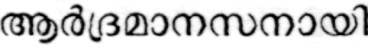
ആര്‍ദ്രമാനസനായി
